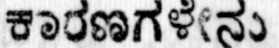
ಕಾರಣಗಳೇನು
